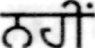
ਨਹੀਂ
